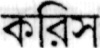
করিস
